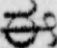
ಈ
